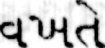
વખતે
